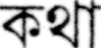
কথা
